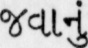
જવાનું
